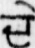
ਦੇ
